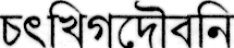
চৎখিগদৌবনি
